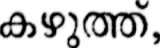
കഴുത്ത്,
